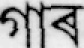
গাৰ
